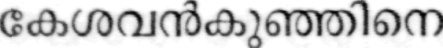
കേശവന്‍കുഞ്ഞിനെ
